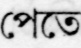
পেতে
